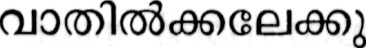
വാതില്‍ക്കലേക്കു
